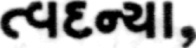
ત્વદન્યા,
